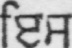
ਇਸ
